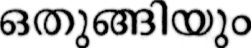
ഒതുങ്ങിയും
